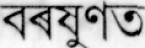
বৰষুণত
